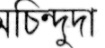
মচিন্দুদা
